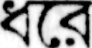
ধরে
